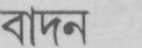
বাদন
